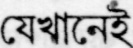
যেখানেই
